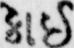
કોઈ
